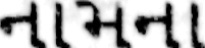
નામના
